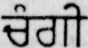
ਚੰਗੀ
